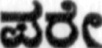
ಪರೇ
